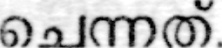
ചെന്നത്.
